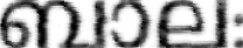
ബാല:
